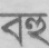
বহু
